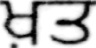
ਖ਼ਤ
